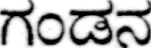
ಗಂಡನ
